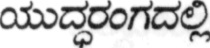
ಯುದ್ಧರಂಗದಲ್ಲಿ
